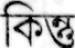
কিন্তু
